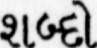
શબ્દો
